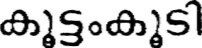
കൂട്ടംകൂടി
